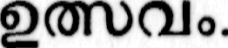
ഉത്സവം.
